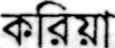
করিয়া
